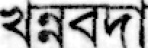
খন্নবদা
